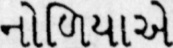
નોળિયાએ
